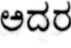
ಅದರ
